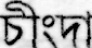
চীংদা
